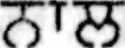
ਨਾਲ
